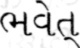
ભવેત્
